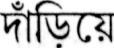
দাঁড়িয়ে
